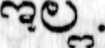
ಇಲ್ಲ.
